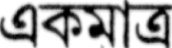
একমাত্র
